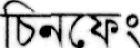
চিনফেং
